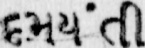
દમયંતી
